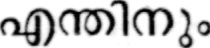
എന്തിനും
